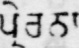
ਪ੍ਰੇਰਨਾ
